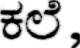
ಕಲೆ,
